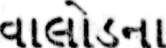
વાલોડના
